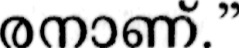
രനാണ്.”
